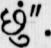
છું".
